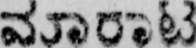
ಮಾರಾಟ
